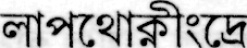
লাপথোক্নীংদ্রে
